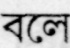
বলে
